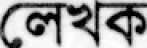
লেখক
